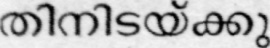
തിനിടയ്ക്കു
